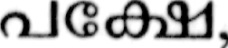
പക്ഷേ,
